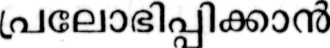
പ്രലോഭിപ്പിക്കാന്‍
